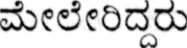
ಮೇಲೇರಿದ್ದರು
